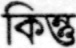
কিন্তু
